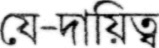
যে-দায়িত্ব
